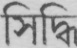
সিদ্ধি
